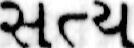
સત્ય
